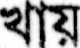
খায়
